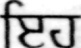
ਇਹ
